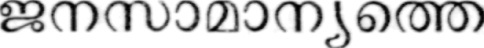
ജനസാമാന്യത്തെ
